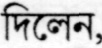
দিলেন,
